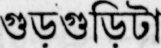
গুড়গুড়িটা
